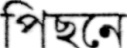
পিছনে
